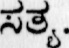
ಸತ್ಯ.
